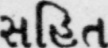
સહિત
